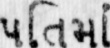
પતિમાં
